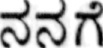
ನನಗೆ
